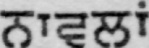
ਨਾਵਲਾਂ
